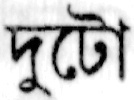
দুটো
